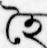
হৈ
